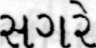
સગરે
